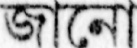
জানো
